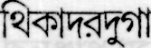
থিকাদরদুগা
